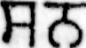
ਸਨ
